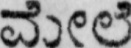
ಮೇಲೆ
